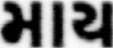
માય
